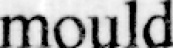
mould
